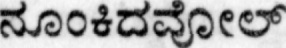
ನೂಂಕಿದವೋಲ್
